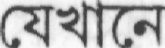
যেখানে
